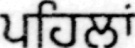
ਪਹਿਲਾਂ
